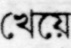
খেয়ে
